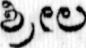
ಶ್ರೀಲ
